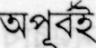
অপূৰ্বই
